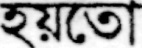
হয়তো
